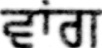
ਵਾਂਗ
